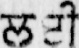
ਲਈ
